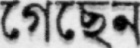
গেছেন
